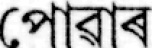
পোৱাৰ
